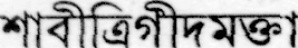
শাবীত্রিগীদমক্তা
